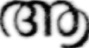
ആ
